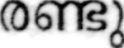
രണ്ടു
